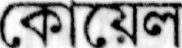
কোয়েল
